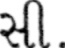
સી.
